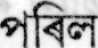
পৰিল
